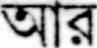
আর
